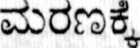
ಮರಣಕ್ಕೆ
